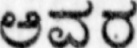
ಅವರ
